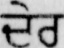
ਦੇਰ
